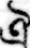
ঐ
